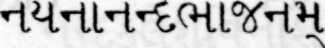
નયનાનન્દભાજનમ્
